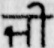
ਜੀ
